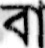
বা
